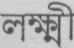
লক্ষ্মী
